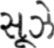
સૂઝે
